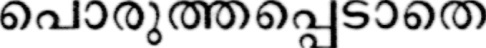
പൊരുത്തപ്പെടാതെ
